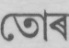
তোৰ
